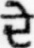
ਦੇ
